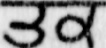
ਤਕ
